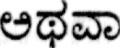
ಅಥವಾ
